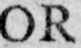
OR
